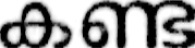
കണ്ട
